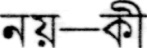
নয়–কী
